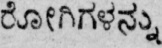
ರೋಗಿಗಳನ್ನು
